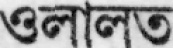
ওলালত
